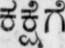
ಕಕ್ಷೆಗೆ
